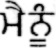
ਮੈਨੂੰ
